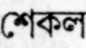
শেকল
